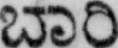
ಬಾರಿ
